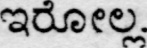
ಇರೋಲ್ಲ.
